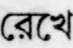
রেখে
